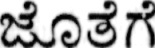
ಜೊತೆಗೆ
